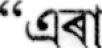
"এৰা
